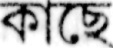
কাছে
